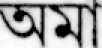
অমা
